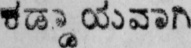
ಕಡ್ಡಾಯವಾಗಿ
